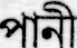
পানী
